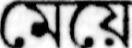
মেয়ে
